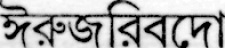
ঈরুজরিবদো
